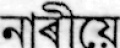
নাৰীয়ে
